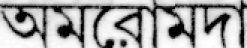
অমরোমদা
